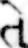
તે
